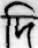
দি
